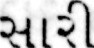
સારી
